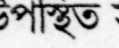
উপস্থিত
